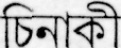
চিনাকী
